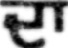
ਦਾ
